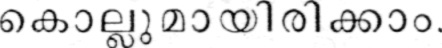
കൊല്ലുമായിരിക്കാം.
